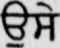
ਉਸੇ
